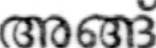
അങ്ങ്
